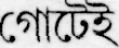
গোটেই
